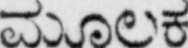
ಮೂಲಕ
